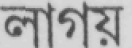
লাগয়
